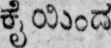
ಕೈಯಿಂದ
